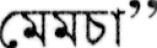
মেমচা”
